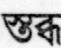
স্তব্ধ
